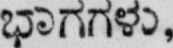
ಭಾಗಗಳು,
